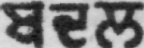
ਬਦਲ
